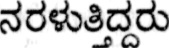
ನರಳುತ್ತಿದ್ದರು
